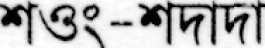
শওং-শদাদা
